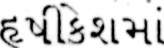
હ્રષીકેશમાં
